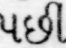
પછી
